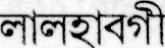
লালহাবগী
